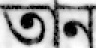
তান
